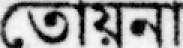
তোয়না
